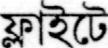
ফ্লাইটে
